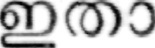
ഇതാ
